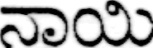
ನಾಯಿ
